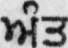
ਅੰਤ
